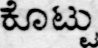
ಕೊಟ್ಟು
